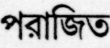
পরাজিত
